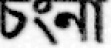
চংনা
